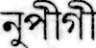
নুপীগী
